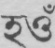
হওঁ
